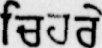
ਚਿਹਰੇ
